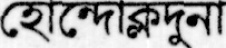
হোন্দোক্লদুনা
